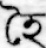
হৈ
